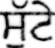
ਸੁੱਟੇ
